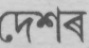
দেশৰ
